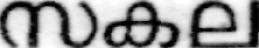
സകല
